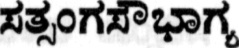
ಸತ್ಸಂಗಸೌಭಾಗ್ಯ
